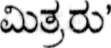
ಮಿತ್ರರು'
